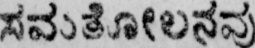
ಸಮತೋಲನವು
